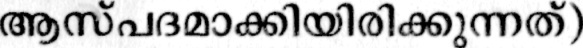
ആസ്പദമാക്കിയിരിക്കുന്നത്)
